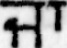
ਜਾ
